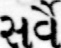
સર્વૈ
